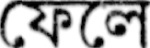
ফেলে
